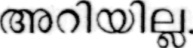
അറിയില്ല.
